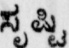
ಸೃಷ್ಟಿ
